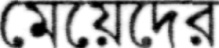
মেয়েদের
